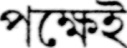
পক্ষেই
